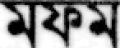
মফম
